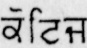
ਕੋਟਿਜ
